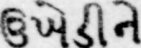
ઉખેડીને
